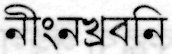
নীংনখ্রবনি
